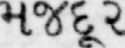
મજદૂર
